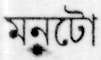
মনটো
